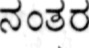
ನಂತರ
